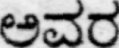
ಅವರ
